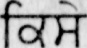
ਕਿਸੇ
